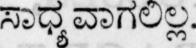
ಸಾಧ್ಯವಾಗಲಿಲ್ಲ.
